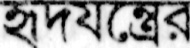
হৃদযন্ত্রের
